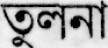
তুলনা
